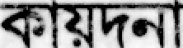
কায়দনা
